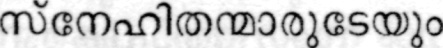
സ്നേഹിതന്മാരുടേയും
